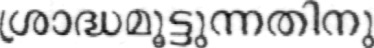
ശ്രാദ്ധമുട്ടുന്നതിനു
